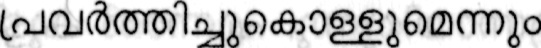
പ്രവര്‍ത്തിച്ചുകൊള്ളുമെന്നും
